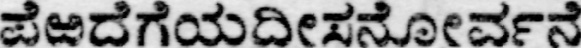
ಪೆಱದೆಗೆಯದೀಸನೋರ್ವನೆ
